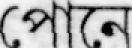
পোনে
